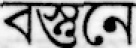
বস্তুনে
